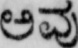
ಅವು
